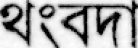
থংবদা
